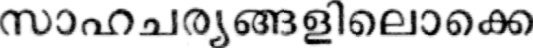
സാഹചര്യങ്ങളിലൊക്കെ
